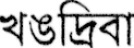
খঙদ্রিবা
